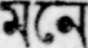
মনে
